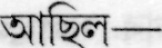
আছিল-
